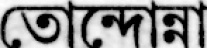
তোন্দোন্না
